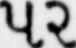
પર
